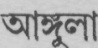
আঙ্গুলা
